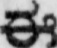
ಈ
